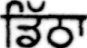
ਡਿੱਠਾ
